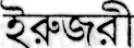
ইরুজরী
